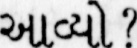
આવ્યો?
